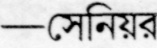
–সেনিয়র
